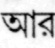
আর
